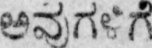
ಅವುಗಳಿಗೆ
